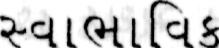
સ્વાભાવિક
